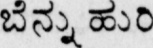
ಬೆನ್ನುಹುರಿ
